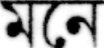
মনে
